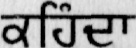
ਕਹਿੰਦਾ
